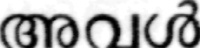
അവള്‍
